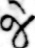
જે
